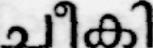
ചീകി
